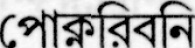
পোক্নরিবনি
